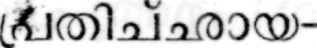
പ്രതിച്ഛായ-
